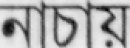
নাচায়
